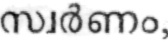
സ്വര്‍ണം,
